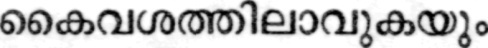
കൈവശത്തിലാവുകയും
